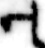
ન
